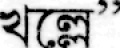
খল্লে”
